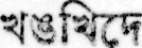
খঙখিদে
